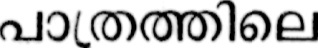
പാത്രത്തിലെ
